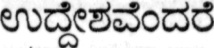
ಉದ್ದೇಶವೆಂದರೆ
